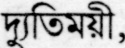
দ্যুতিময়ী,
